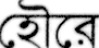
হৌরে
